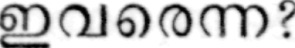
ഇവരെന്ന?
